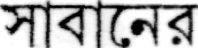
সাবানের
